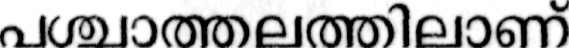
പശ്ചാത്തലത്തിലാണ്
